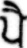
ਪੈ
